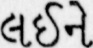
લઈને
